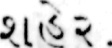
શહેર.
